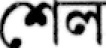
শেল
